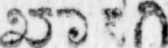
ಖಾಸಗಿ
